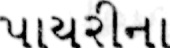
પાયરીના
